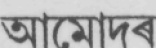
আমোদৰ
